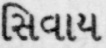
સિવાય
